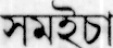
সমইচা
